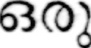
ഒരു
